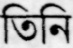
তিনি
